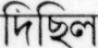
দিছিল
